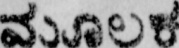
ಮೂಲಕ
